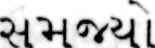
સમજ્યો
